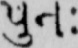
પુનઃઅસીમ
